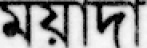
ময়াদা
